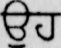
ਉਹ
